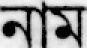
নাম
